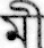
মী
